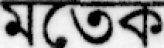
মতেক
